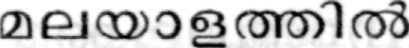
മലയാളത്തില്‍
